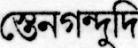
স্তেনগন্দুদি
